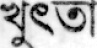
খুৎতা
